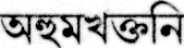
অহুমখক্তনি
